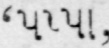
'પપ્પા,
